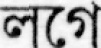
লগে
